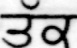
ਤੱਕ
